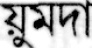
য়ুমদা
